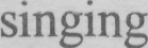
singing
